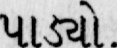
પાડ્યો.
